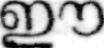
ഈ
